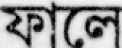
ফালে
